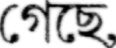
গেছে,
